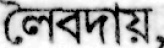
লৈবদায়,
